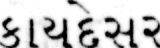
કાયદેસર
